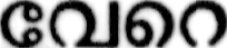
വേറെ
